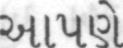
આપણે
